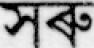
সৰু
